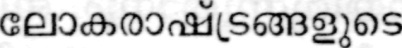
ലോകരാഷ്ട്രങ്ങളുടെ
